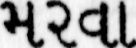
મરવા
